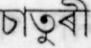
চাতুৰী
